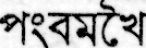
পংবমখৈ
